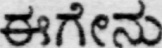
ಈಗೇನು
